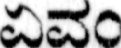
ಏವಂ
